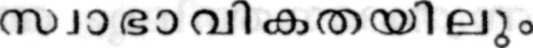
സ്വാഭാവികതയിലും
